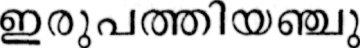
ഇരുപത്തിയഞ്ചു
